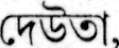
দেউতা,
